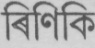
ৰিণিকি
